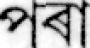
পৰা
